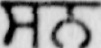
ਸਨ
